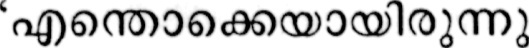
‘എന്തൊക്കെയായിരുന്നു
